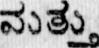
ಮತ್ತು
